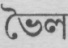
ভৈল
